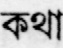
কথা
